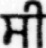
ਸੀ
